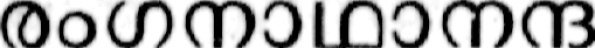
രംഗനാഥാനന്ദ
